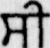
ਸੀ
